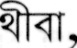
থীবা,
